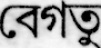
বেগতু
